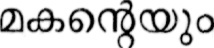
മകന്റെയും
